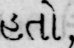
હતો,
